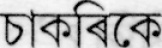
চাকৰিকে
